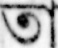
তা
